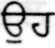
ਉਹ
